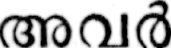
അവര്‍
